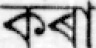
কৰা
